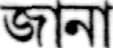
জানা
